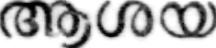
ആശയ
